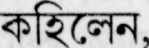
কহিলেন,
